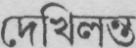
দেখিলন্ত
